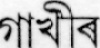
গাখীৰ
